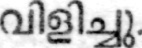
വിളിച്ചു.
